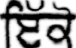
ਇੱਕੋ
